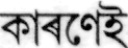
কাৰণেই
